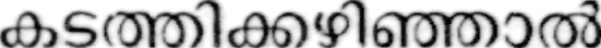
കടത്തിക്കഴിഞ്ഞാല്‍
